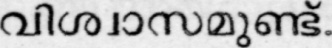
വിശ്വാസമുണ്ട്.
